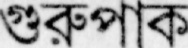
গুরুপাক
